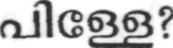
പിള്ളേ?
